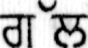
ਗੱਲ
